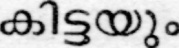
കിട്ടയും
